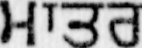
ਮਾਤਰ
